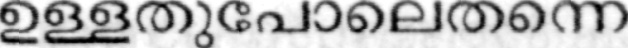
ഉള്ളതുപോലെതന്നെ
